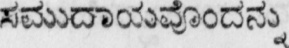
ಸಮುದಾಯವೊಂದನ್ನು
